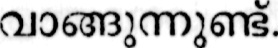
വാങ്ങുന്നുണ്ട്.
